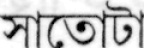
সাতোটা
